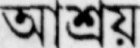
আশ্রয়
